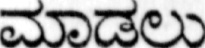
ಮಾಡಲು
